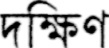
দক্ষিণ
